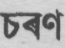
চৰণ
